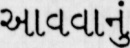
આવવાનું
